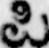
ಪಿ
